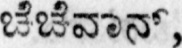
ಚೆಚೆವಾನ್,
